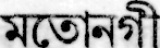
মতোনগী
